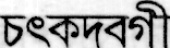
চৎকদবগী
